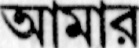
আমার
